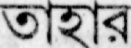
তাহার
